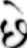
છે
